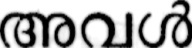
അവള്‍
